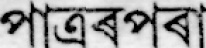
পাত্রৰপৰা
